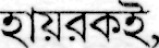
হায়রকই,
